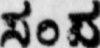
ಸ೦ಪ
